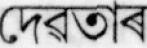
দেৱতাৰ
